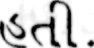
હતી.
